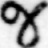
જ
